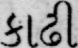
કાઢી
